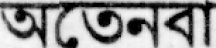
অতেনবা
